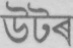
উটৰ
